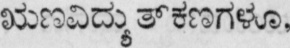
ಋಣವಿದ್ಯುತ್‌ಕಣಗಳೂ,
